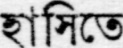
হাসিতে
